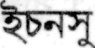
ইচনসু
